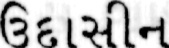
ઉદાસીન
